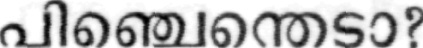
പിഞ്ചെന്തെടാ?
